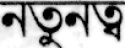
নতুনত্ব
